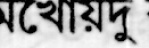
মখোয়দু
